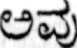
ಅವು
